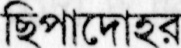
ছিপাদোহর
